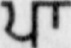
ਪਾ
